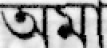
অমা
